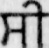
ਸੀ
